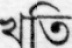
খতি
